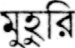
মুহুরি
